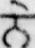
ਨੇ
